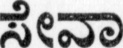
ಸೇವಾ
